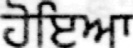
ਹੋਇਆ
